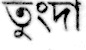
তুংদা
